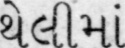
થેલીમાં
